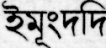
ইমূংদদি
